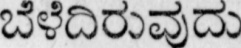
ಬೆಳೆದಿರುವುದು
